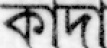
কাদা
